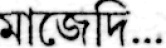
মাজেদি...
